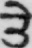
ਤੇ
